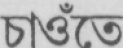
চাওঁতে
